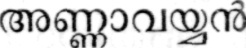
അണ്ണാവയ്യന്‍
